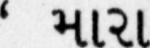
'મારા
